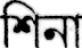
শিনা
